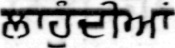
ਲਾਹੁੰਦੀਆਂ
